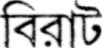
বিরাট
